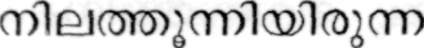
നിലത്തൂന്നിയിരുന്ന
